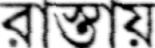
রাস্তায়
